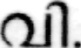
വി.
